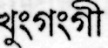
খুংগংগী
